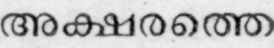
അക്ഷരത്തെ
